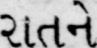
રાતને
